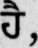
ਹੈ,
